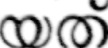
യത്
